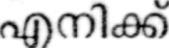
എനിക്ക്
